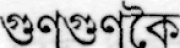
গুণগুণকৈ
